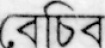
বেচিব
